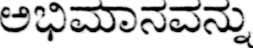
ಅಭಿಮಾನವನ್ನು
